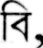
বি,
